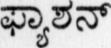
ಫ್ಯಾಶನ್
